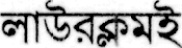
লাউরক্লমই
